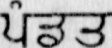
ਪੰਡਤ
